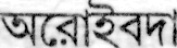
অরোইবদা
